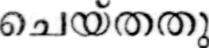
ചെയ്തതു
